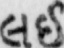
લઈ
